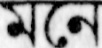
মনে
